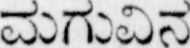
ಮಗುವಿನ
